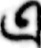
এ
